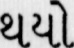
થયો
